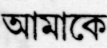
আমাকে
